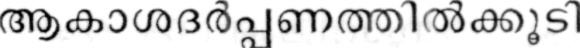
ആകാശദര്‍പ്പണത്തില്‍ക്കൂടി
